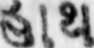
હાથ
